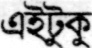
এইটুকু
